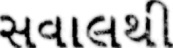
સવાલથી
